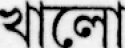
খালো
